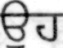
ਉਹ
